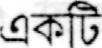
একটি
